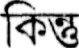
কিন্তু
